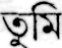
তুমি
